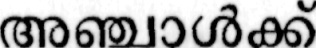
അഞ്ചാള്‍ക്ക്
